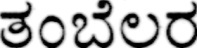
ತಂಬೆಲರ
